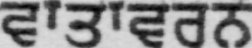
ਵਾਤਾਵਰਨ
